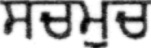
ਸਚਮੁਚ
